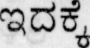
ಇದಕ್ಕೆ
